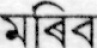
মৰিব
